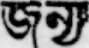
জন্য
